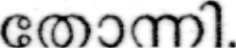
തോന്നി.
